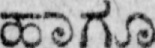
ಹಾಗೂ
